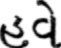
હવે
